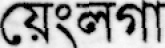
য়েংলগা
